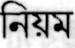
নিয়ম
